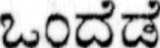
ಒಂದೆಡೆ
